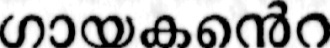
ഗായകന്റെ
